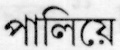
পালিয়ে
